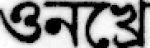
ওনখ্রে
